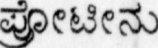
ಪ್ರೋಟೀನು
